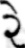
રે
